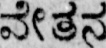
ವೇತನ
